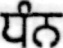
ਧੰਨ
